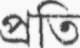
প্রতি
